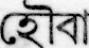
হৌবা
